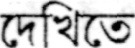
দেখিতে
